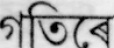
গতিৰে
